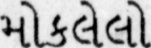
મોકલેલો
